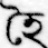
হৈ
